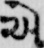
એ
